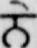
ਨੇ
